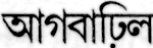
আগবাঢ়িল
